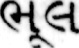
ભૂલ
